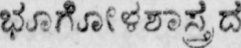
ಭೂಗೋಳಶಾಸ್ತ್ರದ
